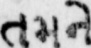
તમને
